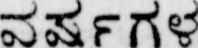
ವರ್ಷಗಳ
